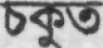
চকুত
